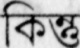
কিন্তু
